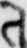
તે
